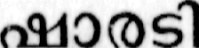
ഷാരടി
